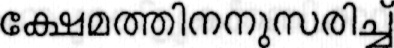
ക്ഷേമത്തിനനുസരിച്ച്
